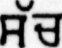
ਸੱਚ
